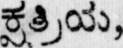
ಕ್ಷತ್ರಿಯ,
